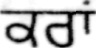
ਕਰਾਂ
